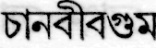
চানবীবগুম
